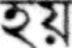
হয়
